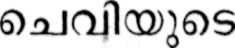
ചെവിയുടെ
